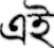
এই
